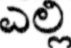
ಎಲ್ಲಿ
